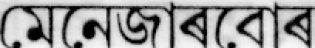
মেনেজাৰবোৰ
